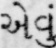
એવું
